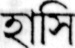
হাসি
